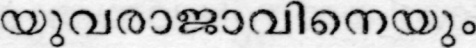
യുവരാജാവിനെയും
